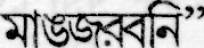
মাঙজরবনি”
